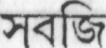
সবজি
